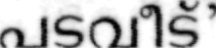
പടവീട്'
